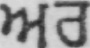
ਅਰ
